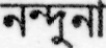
নন্দুনা
